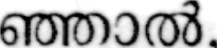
ഞ്ഞാല്‍,
